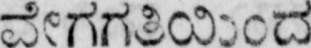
ವೇಗಗತಿಯಿಂದ
